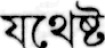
যথেষ্ট
